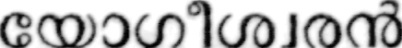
യോഗീശ്വരന്‍
